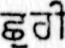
ਛੁਰੀ
